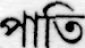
পাতি
